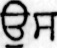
ਉਸ
